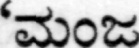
‘ಮಂಜ
